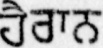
ਹੈਰਾਨ
